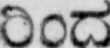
ರಿಂದ
